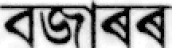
বজাৰৰ
